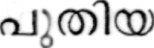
പുതിയ
